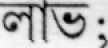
লাভ;
